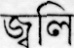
জ্বলি
